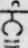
ਨੂੰ
